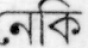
নেকি
